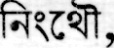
নিংথৌ,
